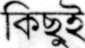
কিছুই
